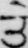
ਤੇ
